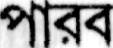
পারব
